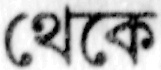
থেকে
